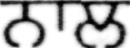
ਨਾਲ
